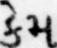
કેમ
